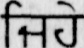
ਜਿਹੇ
